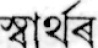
স্বার্থৰ
